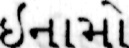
ઈનામો
